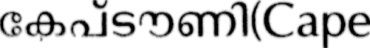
കേപ്ടൌണി(Cape
